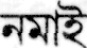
নমাই
